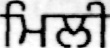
ਮਿਲੀ
